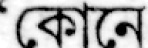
'কোনে
